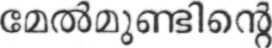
മേല്‍മുണ്ടിന്റെ
